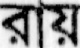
রায়
